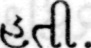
હતી.
